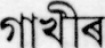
গাখীৰ
